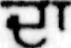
ਦਾ
